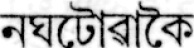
নঘটোৱাকৈ
